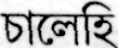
চালেহি
